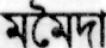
মমৈদা
